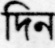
দিন
